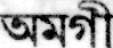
অমগী
